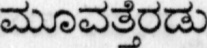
ಮೂವತ್ತೆರಡು
